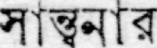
সান্ত্বনার
